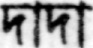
দাদা
